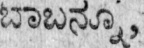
ಬಾಬನ್ನೂ,
